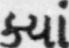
ક્યાં
